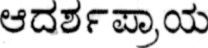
ಆದರ್ಶಪ್ರಾಯ
